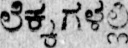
ಲೆಕ್ಕಗಳಲ್ಲಿ
